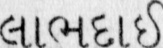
લાભદાઈ
